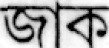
জাক
